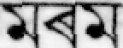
মৰম
